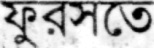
ফুরসতে
